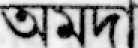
অমদা
